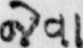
જેવા
